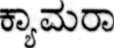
ಕ್ಯಾಮರಾ
